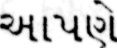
આપણે
